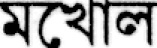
মখোল
